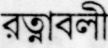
রত্নাবলী
